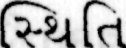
સ્થિતિ
